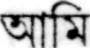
আমি
